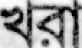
খরা
